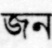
জন
